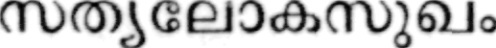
സത്യലോകസുഖം
